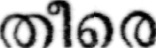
തീരെ
